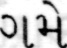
ગમે
